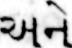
અને
